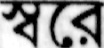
স্বরে
